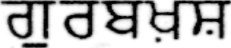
ਗੁਰਬਖ਼ਸ਼
